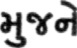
મુજને
